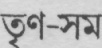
তৃণ-সম
